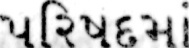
પરિષદમાં
